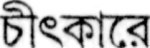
চীৎকারে
